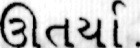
ઊતર્યા.
